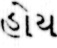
હોય
